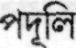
পদূলি
